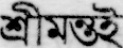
শ্রীমন্তই
